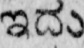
ಇದು
